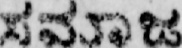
ಸಮಾಜ
